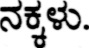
ನಕ್ಕಳು.
